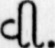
વી.
